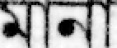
মানা
